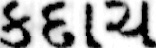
કદાચ
